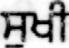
ਸੁਖੀ
